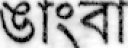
ঙাংবা
